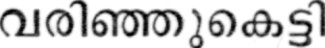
വരിഞ്ഞുകെട്ടി
